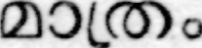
മാത്രം
